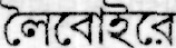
লৈবোইরে
